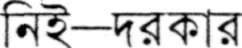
নিই–দরকার
